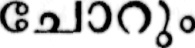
ചോറും
